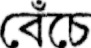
বেঁচে
